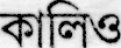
কালিও
